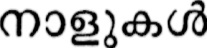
നാളുകള്‍
